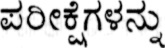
ಪರೀಕ್ಷೆಗಳನ್ನು
